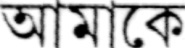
আমাকে
